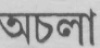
অচলা
